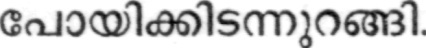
പോയിക്കിടന്നുറങ്ങി.
